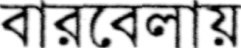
বারবেলায়
